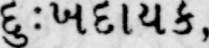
દુઃખદાયક,
